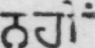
ਨਹੀਂ
